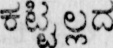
ಕಟ್ಟಿಲ್ಲದ
